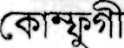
কোম্ফুগী
